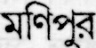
মণিপুর
